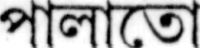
পালাতো
